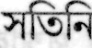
সতিনি
